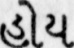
હોય
